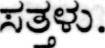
ಸತ್ತಳು.
